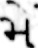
મેં
